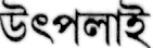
উৎপলাই
